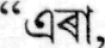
"এৰা,
